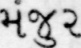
મંજુર
